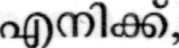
എനിക്ക്,
